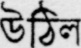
উঠিল
